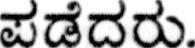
ಪಡೆದರು.
